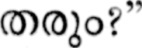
തരും?”
